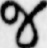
જ
